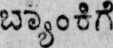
ಬ್ಯಾಂಕಿಗೆ
